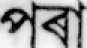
পৰা
